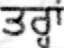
ਤਰ੍ਹਾਂ
